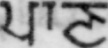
ਪਾਣ
